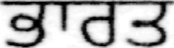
ਭਾਰਤ
